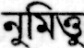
নুমিত্তু
